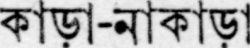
কাড়া-নাকাড়া
